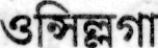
ওন্সিল্লগা
